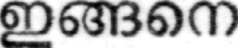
ഇങ്ങനെ
